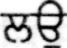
ਲਉ
